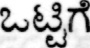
ಒಟ್ಟಿಗೆ
